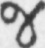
જ
